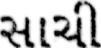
સાચી
